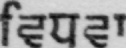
ਵਿਧਵਾ
